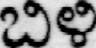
ಬಿಳಿ
